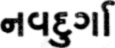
નવદુર્ગા
